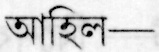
আহিল-
